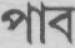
পাব
